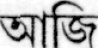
আজি
